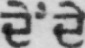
ਦੇਂਦੇ
